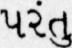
પરંતુ
